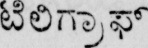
ಟೆಲಿಗ್ರಾಫ್
